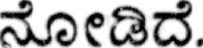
ನೋಡಿದೆ.
